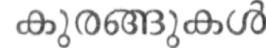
കുരങ്ങുകള്‍
